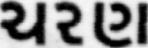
ચરણ
